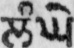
ਲੰਘੇ
